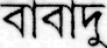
বাবাদু
